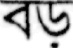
বড়
